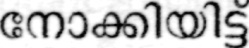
നോക്കിയിട്ട്
